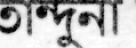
তান্দুনা
